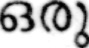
ഒരു
